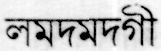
লমদমদগী
